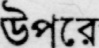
উপরে
